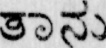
ತಾನು
